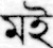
মই
